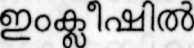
ഇംക്ലീഷില്‍
